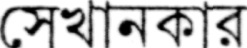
সেখানকার
